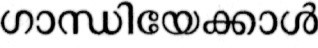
ഗാന്ധിയേക്കാള്‍
